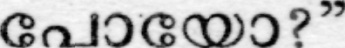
പോയോ?"
